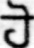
ਹੋ
